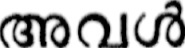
അവള്‍
